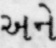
અને
